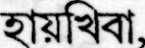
হায়খিবা,
